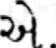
એ.
